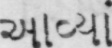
આવ્યાં
